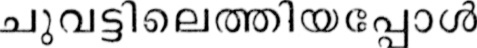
ചുവട്ടിലെത്തിയപ്പോള്‍
